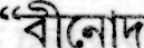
“বীনোদ
